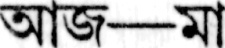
আজ-মা
